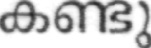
കണ്ടു
